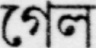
গেল
